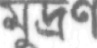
মুদ্রণ
